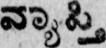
ವ್ಯಾಪ್ತಿ
